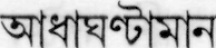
আধাঘণ্টামান
